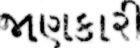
જાણકારી
